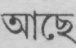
আছে
